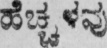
ಹೆಚ್ಚಳವು
